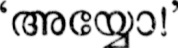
‘അയ്യോ!’
